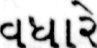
વધારે
